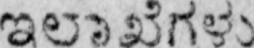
ಇಲಾಖೆಗಳು
